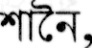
শানৈ,
